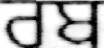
ਰਬ
